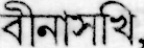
বীনাসখি,
